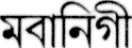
মবানিগী
